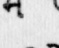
મે
